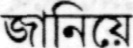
জানিয়ে
